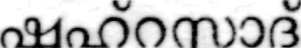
ഷഹ്റസാദ്
